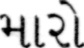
મારો
